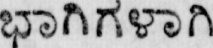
ಭಾಗಿಗಳಾಗಿ
